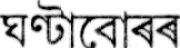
ঘণ্টাবোৰৰ
